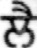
ਲੈ
